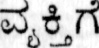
ವ್ಯಕ್ತಿಗೆ
